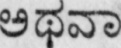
ಅಥವಾ
